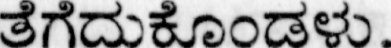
ತೆಗೆದುಕೊಂಡಳು.
